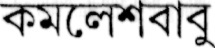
কমলেশবাবু
